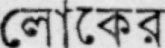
লোকের
